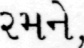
રમને,
